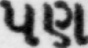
પણ
